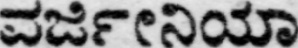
ವರ್ಜೀನಿಯಾ
